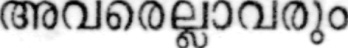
അവരെല്ലാവരും
